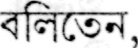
বলিতেন,
